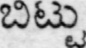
ಬಿಟ್ಟು
